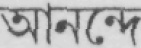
আনন্দে
